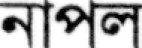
নাপল
